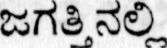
ಜಗತ್ತಿನಲ್ಲಿ
